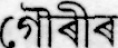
গৌৰীৰ
